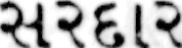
સરદાર
